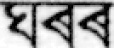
ঘৰৰ
